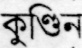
কুণ্ডিন
